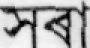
সৰা
